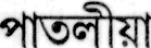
পাতলীয়া
